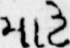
માટે
